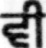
ਵੀ
